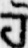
ਹੋ
